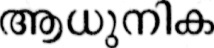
ആധുനിക
